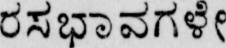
ರಸಭಾವಗಳೇ
